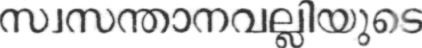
സ്വസന്താനവല്ലിയുടെ
